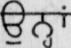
ਉਨ੍ਹਾਂ
